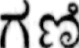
ಗಣಿ
